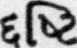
દ્દષ્ટિ
